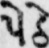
પેઠે
